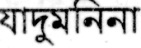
যাদুমনিনা
